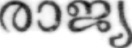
രാജ്യ
